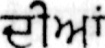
ਦੀਆਂ
